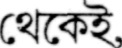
থেকেই,
